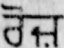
ਰੋਜ਼
